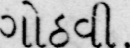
ગોઠવી.
